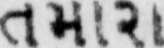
તમારા
